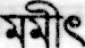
মমীৎ
